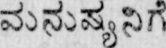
ಮನುಷ್ಯನಿಗೆ
